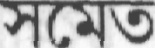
সমেত
